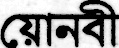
য়োনবী
